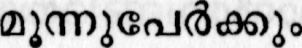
മൂന്നുപേര്‍ക്കും
